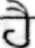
ਹੈ
